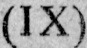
(IX)
